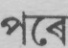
পৰে
